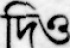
দিও
